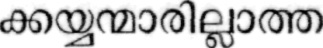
ക്കയ്യന്മാരില്ലാത്ത
